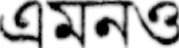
এমনও
